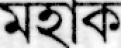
মহাক
